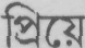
প্ৰিয়ে
